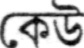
কেউ
